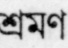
শ্রমণ
